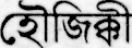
হৌজিক্কী
